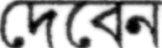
দেবেন
